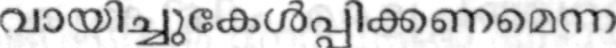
വായിച്ചുകേള്‍പ്പിക്കണമെന്ന
